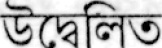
উদ্বেলিত
